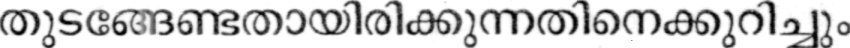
തുടങ്ങേണ്ടതായിരിക്കുന്നതിനെക്കുറിച്ചും
